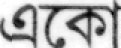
একো
